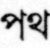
পথ
